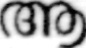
ആ
